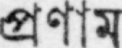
প্রণাম
